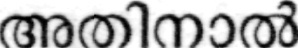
അതിനാല്‍
